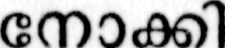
നോക്കി
